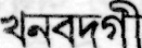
খনবদগী
